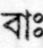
বাঃ
